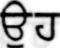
ਉਹ
